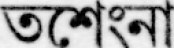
তশেংনা
